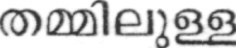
തമ്മിലുള്ള
